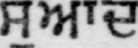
ਸੁਆਦ
